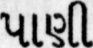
પાણી
